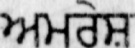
ਅਮਰੇਸ਼
